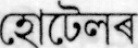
হোটেলৰ
